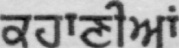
ਕਹਾਣੀਆਂ
